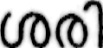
ശരി
